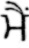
ਮੈਂ
